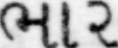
ભાર
